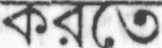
করতে
